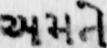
અમને
